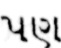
પણ
